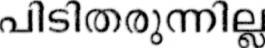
പിടിതരുന്നില്ല
